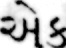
એક
